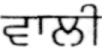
ਵਾਲੀ
